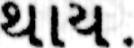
થાય.
